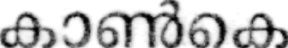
കാണ്‍കെ
